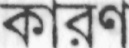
কারণ
